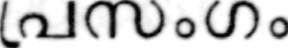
പ്രസംഗം
